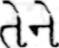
તેને
